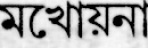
মখোয়না
